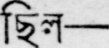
ছিল—
